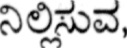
ನಿಲ್ಲಿಸುವ,
